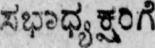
ಸಭಾಧ್ಯಕ್ಷರಿಗೆ
